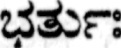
ಭರ್ತುಃ
